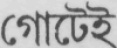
গোটেই
